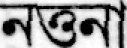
নত্তনা
